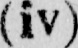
(iv)
